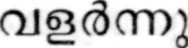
വളര്‍ന്നു
